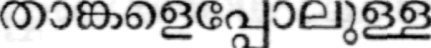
താങ്കളെപ്പോലുള്ള
